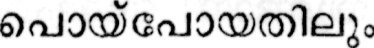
പൊയ്പോയതിലും
